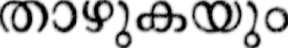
താഴുകയും
